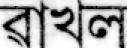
ৱাখল
